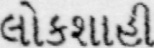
લોકશાહી
